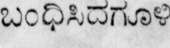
ಬಂಧಿಸಿದಗೂಳಿ
